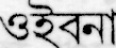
ওইবনা
